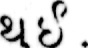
થઈ.
